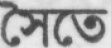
সৈতে
